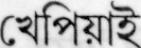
খেপিয়াই
